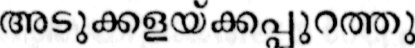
അടുക്കളയ്ക്കപ്പുറത്തു
